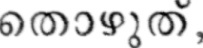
തൊഴുത്,
